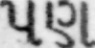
પણ
